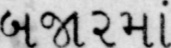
બજારમાં
